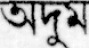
অদুম
